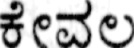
ಕೇವಲ
